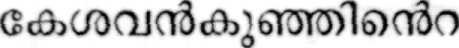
കേശവന്‍കുഞ്ഞിന്റെ
